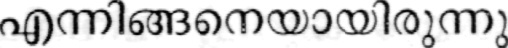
എന്നിങ്ങനെയായിരുന്നു
